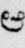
ಆ
